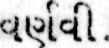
વર્ણવી.
